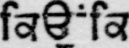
ਕਿਉਂਕਿ
